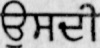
ਉਸਦੀ
